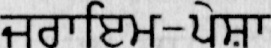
ਜਰਾਇਮ-ਪੇਸ਼ਾ
